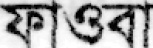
ফাওবা
